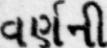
વર્ણની
